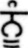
ਨੂੰ
